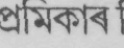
প্রমিকাৰ
